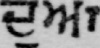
ਦੁਆ
